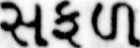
સફળ
